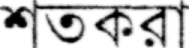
শতকরা
